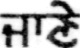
ਜਾਣੇ
